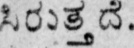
ಸಿರುತ್ತದೆ.
